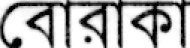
বোরাকা
